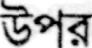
উপর
